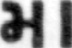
મા
